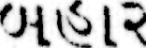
બહાર
